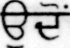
ਉਦੋਂ
